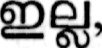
ഇല്ല,
